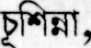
চূশিন্না,
